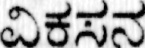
ವಿಕಸನ
